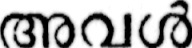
അവള്‍
